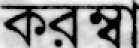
করম্বা
